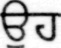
ਉਹ
